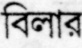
বিলার
